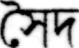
সৈদ
